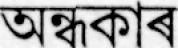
অন্ধকাৰ
